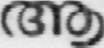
ആ
